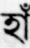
হাঁ
